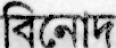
বিনোদ
